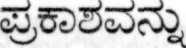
ಪ್ರಕಾಶವನ್ನು
